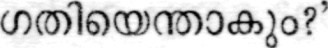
ഗതിയെന്താകും?’
